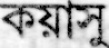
কয়াসু
